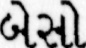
બેસો
